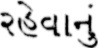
રહેવાનું
